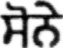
ਸੋਨੇ
